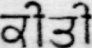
ਕੀਤੀ
